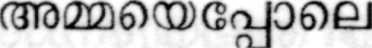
അമ്മയെപ്പോലെ
